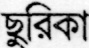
ছুরিকা
